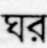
ঘর
